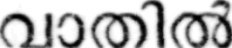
വാതില്‍
